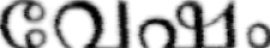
വേഷം
